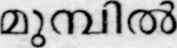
മുമ്പില്‍
